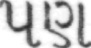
પણ
